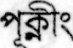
পূক্নীং
